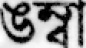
ঙম্বা
